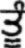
ਤੂੰ
